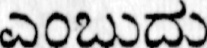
ಎಂಬುದು
